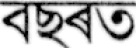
বছৰত
